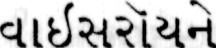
વાઇસરૉયને
